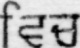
ਵਿਚ
